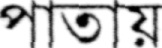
পাতায়
